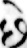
છે
